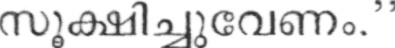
സൂക്ഷിച്ചുവേണം."
